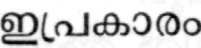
ഇപ്രകാരം
